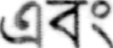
এবং
